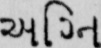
અગ્નિ
